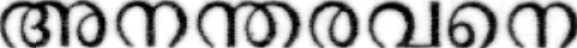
അനന്തരവനെ
